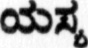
ಯಸ್ಯ
